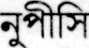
নুপীসি
